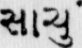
સાચું
